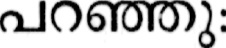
പറഞ്ഞു:
